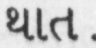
થાત.
